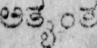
ಅತ್ಯಂತ
